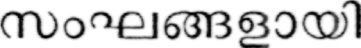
സംഘങ്ങളായി
